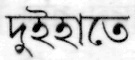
দুইহাতে
